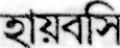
হায়বসি
